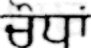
ਚੌਧਾਂ
